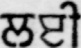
ਲਈ
